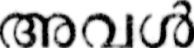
അവള്‍
